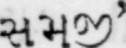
સમજી'
